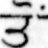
ਤੋਂ
